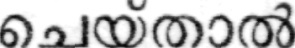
ചെയ്താല്‍
